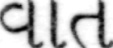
વાત
